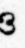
ও
